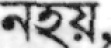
নহয়,
